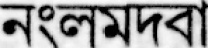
নংলমদবা
